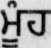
ਮੂੰਹ
